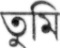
তুমি
